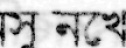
নখে
